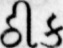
ઠીક
